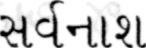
સર્વનાશ
